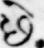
છે.
